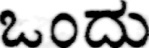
ಒಂದು
